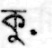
কু.
